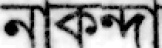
নাকন্দা
